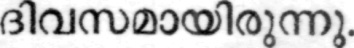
ദിവസമായിരുന്നു.
